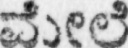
ಮೇಲೆ
